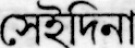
সেইদিনা
